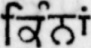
ਕਿੰਨਾਂ
